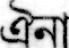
ঐনা
